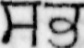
ਸਭ
